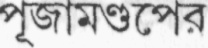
পূজামণ্ডপের
